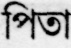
পিতা
